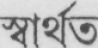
স্বার্থত
